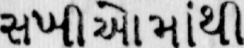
સખીઓમાંથી
